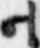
ન
